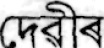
দেৱীৰ
